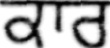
ਕਾਰ
